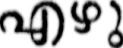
എഴു
